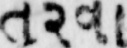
તરવા
